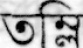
তম্লি
